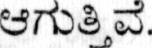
ಆಗುತ್ತಿವೆ.
